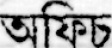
অফিচ
